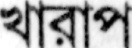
খারাপ
